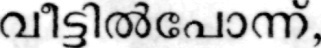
വീട്ടില്‍പോന്ന്,
